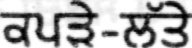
ਕਪੜੇ-ਲੱਤੇ
